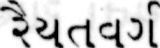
રૈયતવર્ગ
